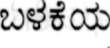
ಬಳಕೆಯ
